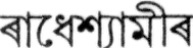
ৰাধেশ্যামীৰ
